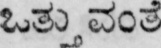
ಒತ್ತುವಂತೆ
